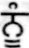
ਨੂੰ
